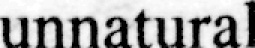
unnatural
